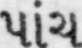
પાંચ
